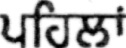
ਪਹਿਲਾਂ
